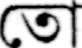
তো
